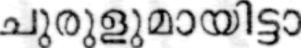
ചുരുളുമായിട്ടാ
